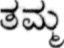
ತಮ್ಮ
